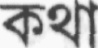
কথা
